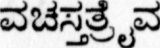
ವಚಸ್ತತ್ರೈವ
